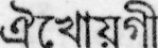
ঐখোয়গী
